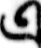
এ
